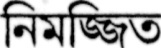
নিমজ্জিত
